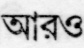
আরও
